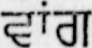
ਵਾਂਗ
